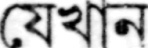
যেখান
